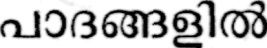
പാദങ്ങളില്‍
